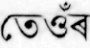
তেওঁৰ
